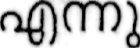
എന്നു
